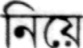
নিয়ে
